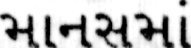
માનસમાં
